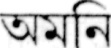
অমনি
